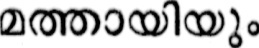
മത്തായിയും
